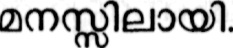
മനസ്സിലായി.
